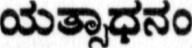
ಯತ್ಸಾಧನಂ
